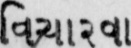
વિચારવા
